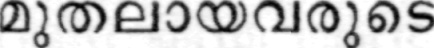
മുതലായവരുടെ
